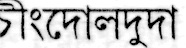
চীংদোলদুদা
